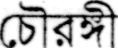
চৌরঙ্গী
